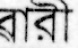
ৱারী
